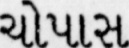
ચોપાસ
